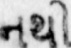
નથી
